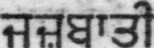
ਜਜ਼ਬਾਤੀ
